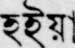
হইয়া
